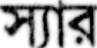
স্যার
